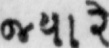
જ્યારે
